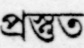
প্রস্তুত
